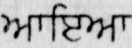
ਆਇਆ
